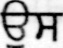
ਉਸ
